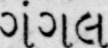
ગંગલ
